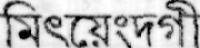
মিৎয়েংদগী
